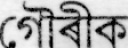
গৌৰীক
